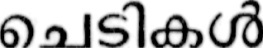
ചെടികള്‍
